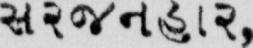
સરજનહાર,
